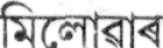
মিলোৱাৰ
